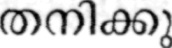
തനിക്കു
